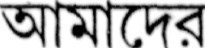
আমাদের
